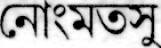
নোংমতসু
